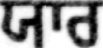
ਯਾਰ
